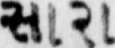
સારા
